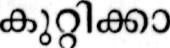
കുറ്റിക്കാ
